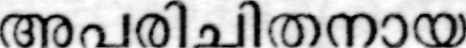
അപരിചിതനായ
